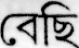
বেছি
